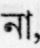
না,
